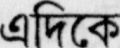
এদিকে
